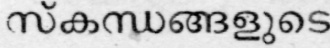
സ്കന്ധങ്ങളുടെ
